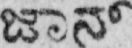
ಜಾನ್
